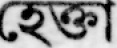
হেক্তা
